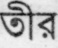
তীর
